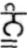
ਨੂੰ
